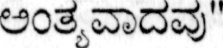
ಅಂತ್ಯವಾದವು”
